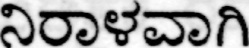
ನಿರಾಳವಾಗಿ
